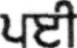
ਪਈ
